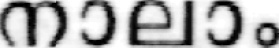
നാലാം
